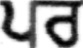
ਪਰ
